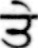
ਤੇ
